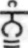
ਨੂੰ
